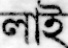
লাই
